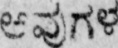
ಅವುಗಳ
